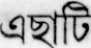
এছাটি
